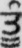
ਤੂੰ
